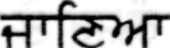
ਜਾਣਿਆ
